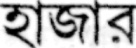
হাজার
